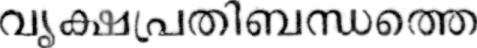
വൃക്ഷപ്രതിബന്ധത്തെ
